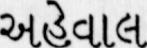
અહેવાલ
